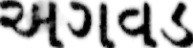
અગવડ
